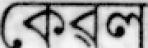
কেৱল
